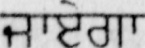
ਜਾਏਗਾ
